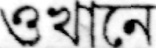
ওখানে
